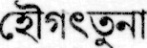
হৌগৎতুনা
